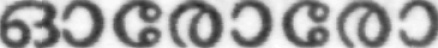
ഓരോരോ
